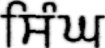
ਸਿੰਘ
